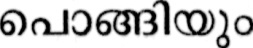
പൊങ്ങിയും
